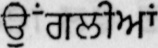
ਉਂਗਲੀਆਂ
